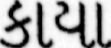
કાયા
